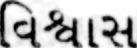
વિશ્વાસ
